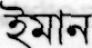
ইমান
